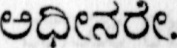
ಅಧೀನರೇ.
